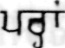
ਪਰ੍ਹਾਂ
